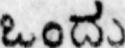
ಒಂದು
